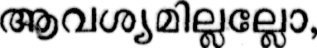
ആവശ്യമില്ലല്ലോ,
